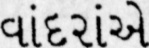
વાંદરાંએ
